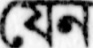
যেন
